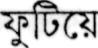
ফুটিয়ে
